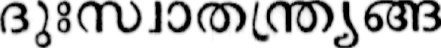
ദുഃസ്വാതന്ത്ര്യങ്ങ
